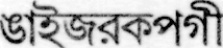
ঙাইজরকপগী
